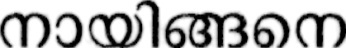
നായിങ്ങനെ
